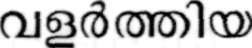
വളര്‍ത്തിയ
